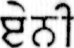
ਏਨੀ
